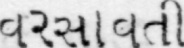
વરસાવતી
